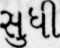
સુધી
